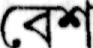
বেশ
